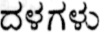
ದಳಗಳು
